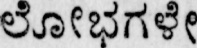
ಲೋಭಗಳೇ
